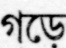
গড়ে
